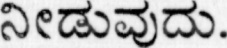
ನೀಡುವುದು.
